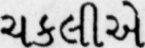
ચકલીએ
